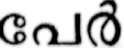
പേര്‍
